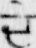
ਦੇ
